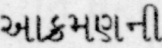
આક્રમણની
